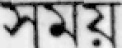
সময়
